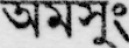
অমসুং
